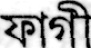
ফাগী
